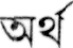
অর্থ
